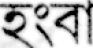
হংবা
